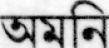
অমনি
